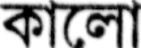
কালো
